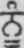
ਨੂੰ
